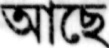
আছে
